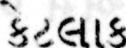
કેટલાક
